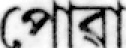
পোৱা
